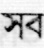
সব
